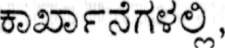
ಕಾರ್ಖಾನೆಗಳಲ್ಲಿ,
